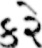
કરે
